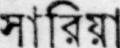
সারিয়া
